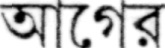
আগের
